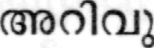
അറിവു
